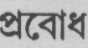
প্ৰবোধ
